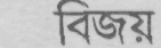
বিজয়
